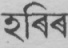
হৰিৰ
